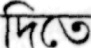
দিতে
